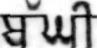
ਬੱਘੀ
